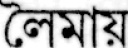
লৈমায়
